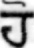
ਹੋ
